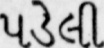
પડેલી
